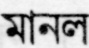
মানল
